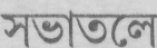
সভাতলে
